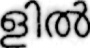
ളില്‍
